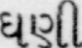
ઘણી
